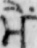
ਮੈਂ
